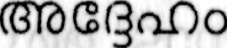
അദ്ദേഹം
